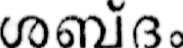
ശബ്ദം
